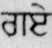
ਗਏ
